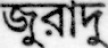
জুরাদু
